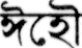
ঈহৌ
